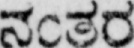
ನಂತರ
